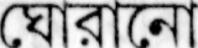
ঘোরানো
